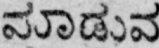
ಮಾಡುವ
